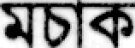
মচাক
